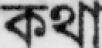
কথা
